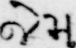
જેમ
